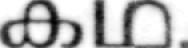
കഥ.
